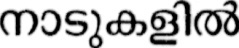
നാടുകളില്‍
